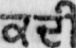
ਕਦੀ
